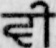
ਵੀ
